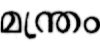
മന്ത്രം
